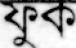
ফুক
